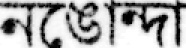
নঙোন্দা
